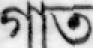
গাত
